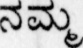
ನಮ್ಮ
